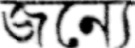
জন্যে
